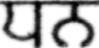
ਧਨ
